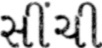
સીંચી
